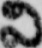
ವಿ
